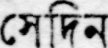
সেদিন
